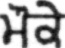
ਮੌਕੇ
